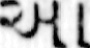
આ
